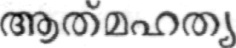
ആത്മഹത്യ
